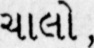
ચાલો,
